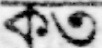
কত
